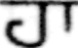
ਹਾਂ
